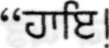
''ਹਾਇ!
